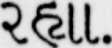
રહ્યા.
